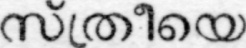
സ്ത്രീയെ
